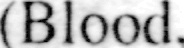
(Blood,
